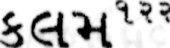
કલમ૧૨૨
